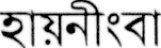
হায়নীংবা
